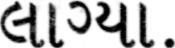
લાગ્યા.
